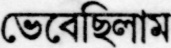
ভেবেছিলাম
